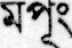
মপূং
